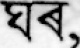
ঘৰ,
